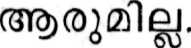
ആരുമില്ല.
